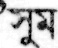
’সুম
